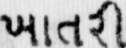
ખાતરી
